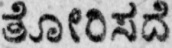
ತೋರಿಸದೆ
